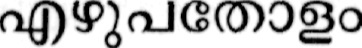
എഴുപതോളം
